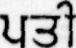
ਪਤੀ
